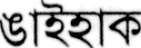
ঙাইহাক
